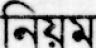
নিয়ম
